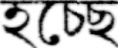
হচ্ছে
